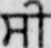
ਸੀ
